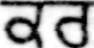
ਕਰ
